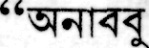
“অনাববু
